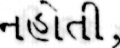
નહોતી,
